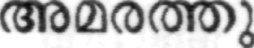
അമരത്തു
